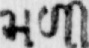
મળી
